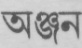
অঞ্জন
